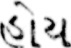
હોય
